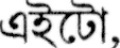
এইটো,
